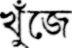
খুঁজে
